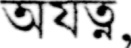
অযত্ন,
